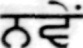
ਨਵੇਂ
